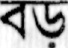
বড়
